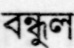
বন্ধুল
